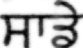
ਸਾਡੇ
